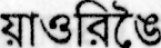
য়াওরিঙৈ
